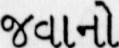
જવાનો
